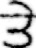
ਤੇ
